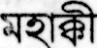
মহাক্কী
